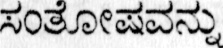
ಸಂತೋಷವನ್ನು
